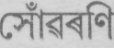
সোঁৱৰণি
